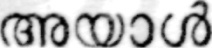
അയാള്‍
